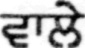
ਵਾਲੇ
